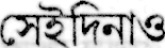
সেইদিনাও
